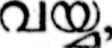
വയ്യ,
